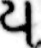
ય
